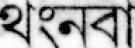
থংনবা
